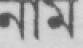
নাম
